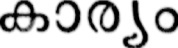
കാര്യം
